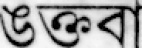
ঙক্তবা
